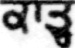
ਕਾੜ੍ਹ
